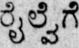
ರೈಲ್ವೆಗೆ
